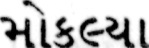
મોકલ્યા
